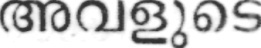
അവളുടെ
